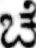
ಚೆ
